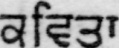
ਕਵਿਤਾ
